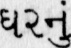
ઘરનું
